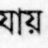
যায়
